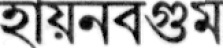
হায়নবগুম
